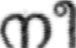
നീ
